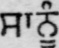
ਸਾਨੂੰ
